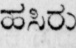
ಹಸಿರು
